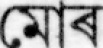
মোৰ
